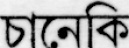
চানেকি
